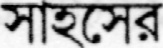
সাহসের
